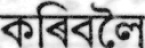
কৰিবলৈ
